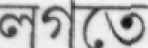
লগতে
